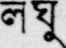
লঘু
